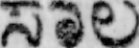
ಸಾಲ
